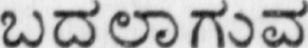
ಬದಲಾಗುವ
